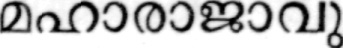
മഹാരാജാവു
